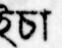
ইচা
